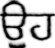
ਉਹ
